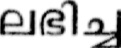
ലഭിച്ച
